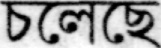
চলেছে
